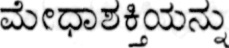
ಮೇಧಾಶಕ್ತಿಯನ್ನು
